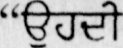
''ਉਹਦੀ
